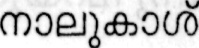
നാലുകാശ്
